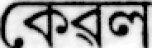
কেৱল
